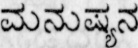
ಮನುಷ್ಯನ
